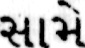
સામે
